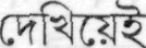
দেখিয়েই
